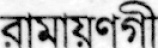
রামায়ণগী
